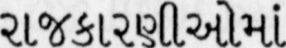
રાજકારણીઓમાં
